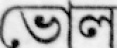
ভোল
